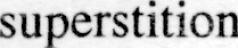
superstition
